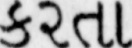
કરતા
